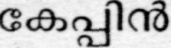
കേപ്പിന്‍
